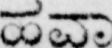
ಹವಾ
